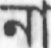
না
